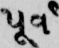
પૂર્વ
